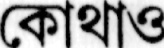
কোথাও
